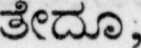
ತೇದೂ,
